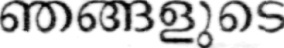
ഞങ്ങളുടെ
